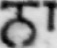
ਨਾ
